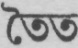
তৈত
